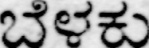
ಬೆಳಕು
